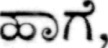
ಹಾಗೆ,
